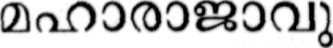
മഹാരാജാവു
